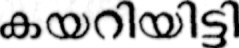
കയറിയിട്ടി
